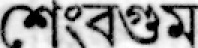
শেংবগুম
